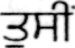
ਤੁਸੀਂ
